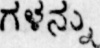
ಗಳನ್ನು
